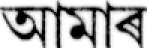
আমাৰ
